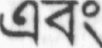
এবং
